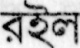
রইল
